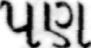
પણ
